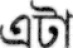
এটা
